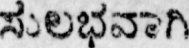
ಸುಲಭವಾಗಿ
